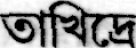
তাখিদ্রে
